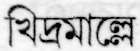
খিদ্রমাল্লে
